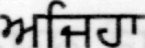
ਅਜਿਹਾ
